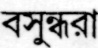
বসুন্ধরা
